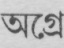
অগ্ৰে
